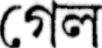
গেল
